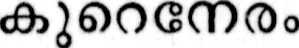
കുറെനേരം
